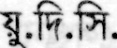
য়ু.দি.সি.
